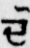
ਦੋ
